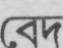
বেদ
